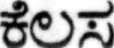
ಕೆಲಸ
